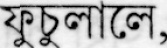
ফুচুলালে,
